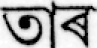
তাৰ
